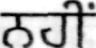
ਨਹੀਂ
